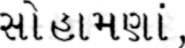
સોહામણાં,
